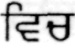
ਵਿਚ
